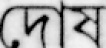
দোষ
